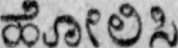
ಹೋಲಿಸಿ
